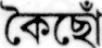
কৈছোঁ
